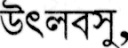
উৎলবসু,
